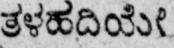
ತಳಹದಿಯೇ
